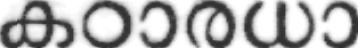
കഠാരധാ
